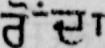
ਰੋਂਦਾ
